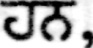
ਹਨ,
